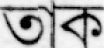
তাক
